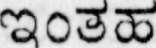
ಇಂತಹ
